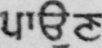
ਪਾਉਣ
